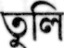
তুলি
